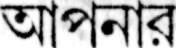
আপনার
